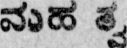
ಮಹತ್ವ
